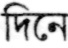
দিনে
